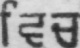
ਵਿਚ
